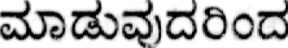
ಮಾಡುವುದರಿಂದ
